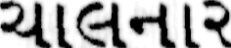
ચાલનાર
